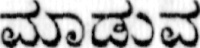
ಮಾಡುವ
